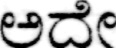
ಅದೇ
